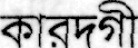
কারদগী
